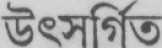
উৎসৰ্গিত
